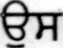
ਉਸ
